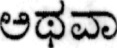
ಅಥವಾ
